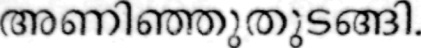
അണിഞ്ഞുതുടങ്ങി.
